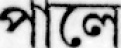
পালে
